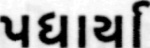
પધાર્યા
